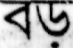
বড়
